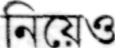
নিয়েও
